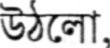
উঠলো,
